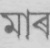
মাৰ
